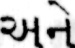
અને
